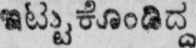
ಇಟ್ಟುಕೊಂಡಿದ್ದ
